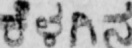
ಕೆಳಗಿನ
